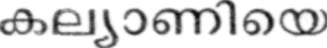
കല്യാണിയെ
